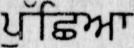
ਪੁੱਛਿਆ
